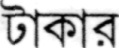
টাকার
